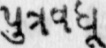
પુત્રવધૂ
